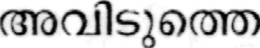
അവിടുത്തെ
